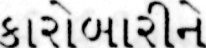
કારોબારીને
